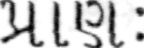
પ્રાણઃ
